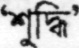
‘শুদ্ধি’
